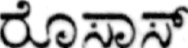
ರೊಸಾಸ್
